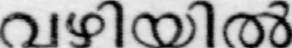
വഴിയില്‍
